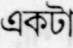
একটা
